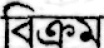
বিক্রম
